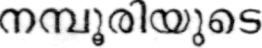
നമ്പൂരിയുടെ
